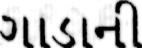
ગાડાની
